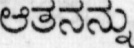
ಆತನನ್ನು
